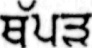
ਥੱਪੜ
